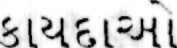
કાયદાઓ
